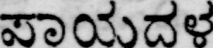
ಪಾಯದಳ
